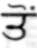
ਤੋਂ
